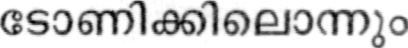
ടോണിക്കിലൊന്നും
